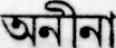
অনীনা
